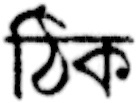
ঠিক
